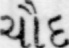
ચૌદ
